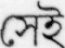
সেই
